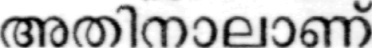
അതിനാലാണ്
